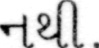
નથી.
